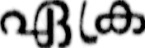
ഏക്ര
